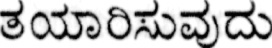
ತಯಾರಿಸುವುದು
